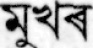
মুখৰ
